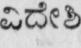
ವಿದೇಶಿ
